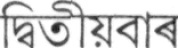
দ্বিতীয়বাৰ
